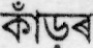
কাঁড়ৰ
